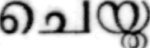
ചെയ്ത
